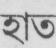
হাত
